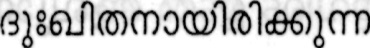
ദുഃഖിതനായിരിക്കുന്ന
